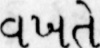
વખતે
